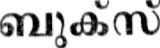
ബുക്സ്
